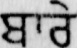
ਬਾਰੇ
